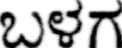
ಬಳಗ
